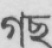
গছ
